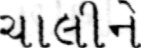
ચાલીને
